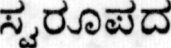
ಸ್ವರೂಪದ
